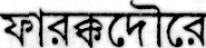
ফারক্কদৌরে
